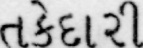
તકેદારી
